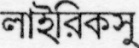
লাইরিকসু
